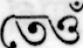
তেওঁ
